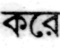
করে
